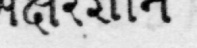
અક્ષરજ્ઞાન
